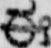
ಈ
